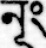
নূং
